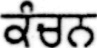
ਕੰਚਨ
